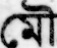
মৌ
